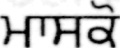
ਮਾਸਕੋ
